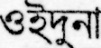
ওইদুনা
